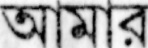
আমার
